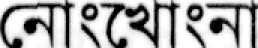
নোংখোংনা
